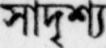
সাদৃশ্য
